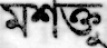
মশক্তু
